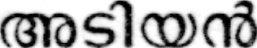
അടിയന്‍
